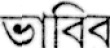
ভাবিব
